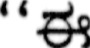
"ಈ
